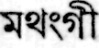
মথংগী
